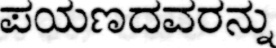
ಪಯಣದವರನ್ನು
